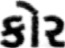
કોર
